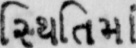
સ્થિતિમાં
